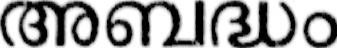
അബദ്ധം
